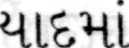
યાદમાં
